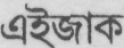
এইজাক
